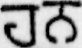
ਹਨ
